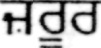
ਜ਼ਰੂਰ
